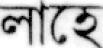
লাহে
